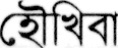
হৌখিবা
